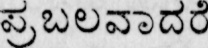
ಪ್ರಬಲವಾದರೆ
